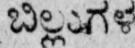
ಬಿಲ್ಲುಗಳ
